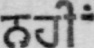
ਨਹੀਂ
